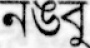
নঙবু
